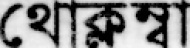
থোক্লম্বা
